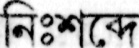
নিঃশব্দে
